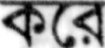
করে
